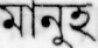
মানুহ
